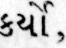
કર્યો,
